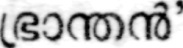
ഭ്രാന്തന്‍’
